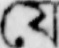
যে
